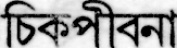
চিকপীবনা
